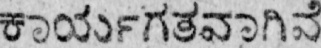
ಕಾರ್ಯಗತವಾಗಿವೆ
